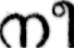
നീ
